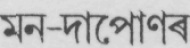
মন-দাপোণৰ
